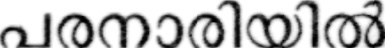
പരനാരിയില്‍
